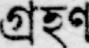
গ্রহণ
